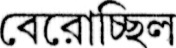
বেরোচ্ছিল
